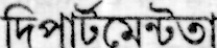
দিপার্টমেন্টতা
